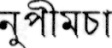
নুপীমচা
